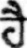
ਹੈ
